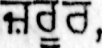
ਜ਼ਰੂਰ,
